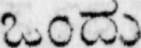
ಒಂದು
